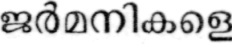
ജര്‍മനികളെ
